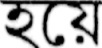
হয়ে
